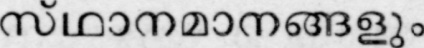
സ്ഥാനമാനങ്ങളും
